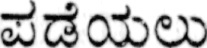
ಪಡೆಯಲು
